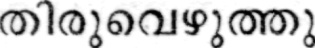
തിരുവെഴുത്തു
